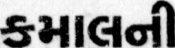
કમાલની
